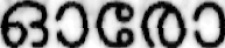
ഓരോ
